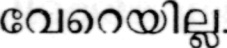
വേറെയില്ല.
